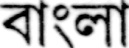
বাংলা
